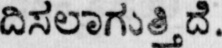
ದಿಸಲಾಗುತ್ತಿದೆ.
